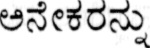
ಅನೇಕರನ್ನು
